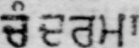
ਚੰਦਰਮਾ
